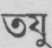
তযু
